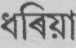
ধৰিয়া
